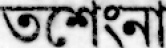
তশেংনা
